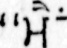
''ਮੈਂ
